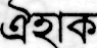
ঐহাক
